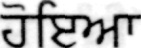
ਹੋਇਆ
